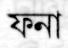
ফনা
